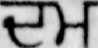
ਦਮ
